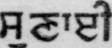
ਸੁਣਾਈ
